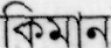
কিমান
